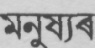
মনুষ্যৰ
